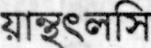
য়ান্থৎলসি
